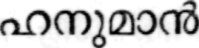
ഹനുമാന്‍
